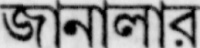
জানালার
